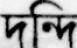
দন্দি
